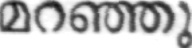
മറഞ്ഞു
